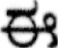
ಈ
